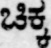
ಚಿಕ್ಕ
